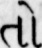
તો
